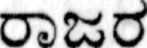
ರಾಜರ
